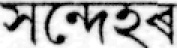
সন্দেহৰ
